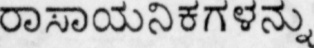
ರಾಸಾಯನಿಕಗಳನ್ನು
